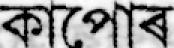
কাপোৰ
